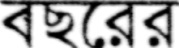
বছরের
